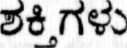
ಶಕ್ತಿಗಳು
